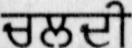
ਚਲਦੀ
